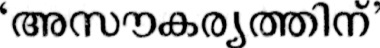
‘അസൌകര്യത്തിന്’
